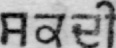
ਸਕਦੀ
